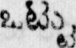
ಒಟ್ಟು
